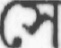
সে
